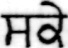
ਸਕੇ
